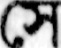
সে
